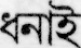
ধনাই
